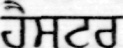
ਹੈਸਟਰ
